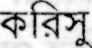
করিসু
